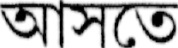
আসতে
